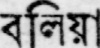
বলিয়া
